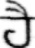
ਹੈ
